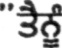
''ਤੈਨੂੰ
